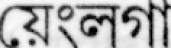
য়েংলগা
